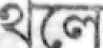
থলে
